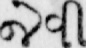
જેવી
